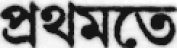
প্ৰথমতে
